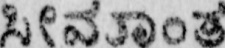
ಸೀಮಾಂತ
